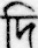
দি
